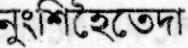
নুংশিহৈতেদা
